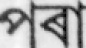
পৰা
